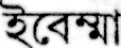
ইবেম্মা
